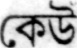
কেউ
